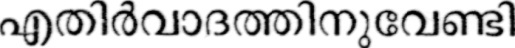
എതിര്‍വാദത്തിനുവേണ്ടി
